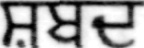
ਸ਼ਬਦ
